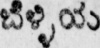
ಬೆಳ್ಳಿಯ
